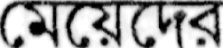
মেয়েদের
